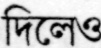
দিলেও
